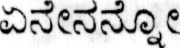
ಏನೇನನ್ನೋ
